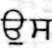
ਉਸ
